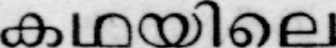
കഥയിലെ
